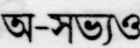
অ-সভ্যও
